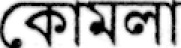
কোমলা
